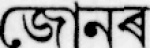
জোনৰ
